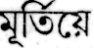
মূর্তিয়ে
